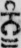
ਨੂੰ
